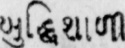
બુદ્ધિશાળી
